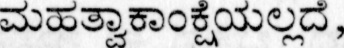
ಮಹತ್ವಾಕಾಂಕ್ಷೆಯಲ್ಲದೆ,
